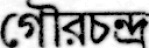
গৌরচন্দ্র
